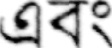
এবং
